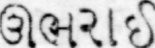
ઊભરાઈ
